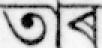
তাৰ
